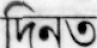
দিনত
